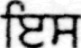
ਇਸ
